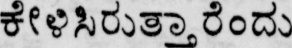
ಕೇಳಿಸಿರುತ್ತಾರೆಂದು
